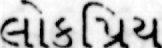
લોકપ્રિય
